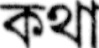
কথা
